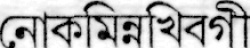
নোকমিন্নখিবগী
